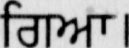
ਗਿਆ।
